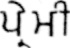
ਪ੍ਰੇਮੀ
